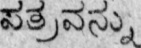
ಪತ್ರವನ್ನು
